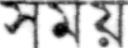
সময়
